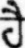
ਹੈ
